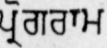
ਪ੍ਰੋਗਰਾਮ
